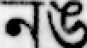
নঙ
